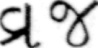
વ્રજ
